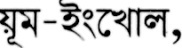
য়ূম-ইংখোল,
